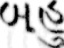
બહુ
